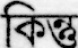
কিন্তু
